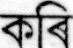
কৰি
